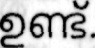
ഉണ്ട്.
